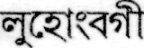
লুহোংবগী
